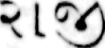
રાજી
